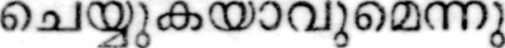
ചെയ്യുകയാവുമെന്നു
